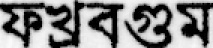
ফখ্রবগুম
